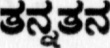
ತನ್ನತನ
